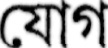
যোগ
